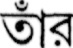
তাঁর
